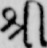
શ્રી
